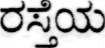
ರಸ್ತೆಯ
